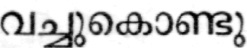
വച്ചുകൊണ്ടു
